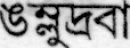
ঙম্লুদ্রবা
